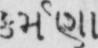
કર્મણા
